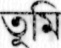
তুমি
